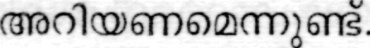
അറിയണമെന്നുണ്ട്.
